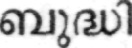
ബുദ്ധി
